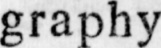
Graphy
